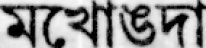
মখোঙদা
